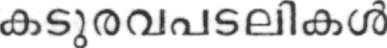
കടുരവപടലികള്‍
